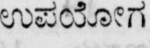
ಉಪಯೋಗ
